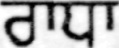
ਰਾਧਾ
